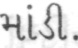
માંડી.
